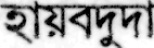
হায়বদুদা
